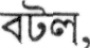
বটল,
